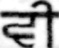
ਵੀ
